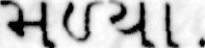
મળ્યા.
